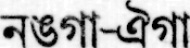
নঙগা-ঐগা
